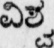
ವಿಶ್ವ
